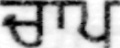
ਚਾਪ
